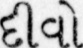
દીવો
